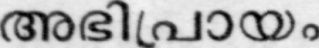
അഭിപ്രായം
